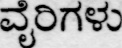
ವೈರಿಗಳು
